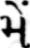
મેં
